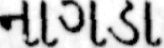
નાગડા
